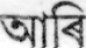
আৰি
